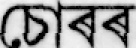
চোৰৰ
